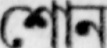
শোন
